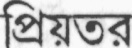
প্রিয়তর
